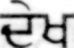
ਦੇਖ
